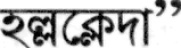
হল্লক্লেদা”
